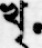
খৃ.
